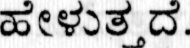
ಹೇಳುತ್ತದೆ.
